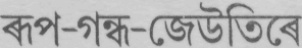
ৰূপ-গন্ধ-জেউতিৰে
